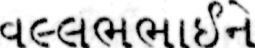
વલ્લભભાઈને
